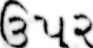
ઉપર
